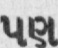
પણ
